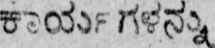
ಕಾರ್ಯಗಳನ್ನು
